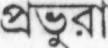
প্রভুরা
